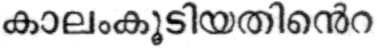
കാലംകൂടിയതിന്റെ
